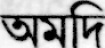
অমদি
